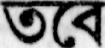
তবে
